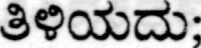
ತಿಳಿಯದು;
